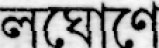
লঘোণে
